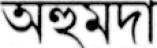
অহুমদা
